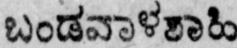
ಬಂಡವಾಳಶಾಹಿ
